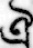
ঐ
